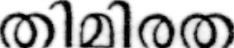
തിമിരത
